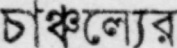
চাঞ্চল্যের
